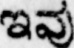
ಇವು
